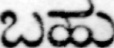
ಬಹು
